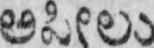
ಅಪೀಲು
